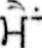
ਮੈਂ
